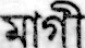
মাগী
